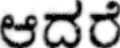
ಆದರೆ
